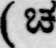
(ಚ
